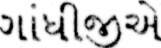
ગાંધીજીએ
